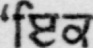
'ਇਕ
